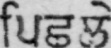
ਪਿਛਲੇ
